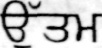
ਉੱਤਮ
